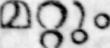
മറ്റും
